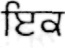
ਇਕ
